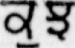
ਕੁਝ
